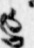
હું
